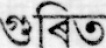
গুৰিত
